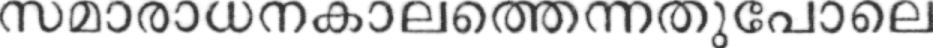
സമാരാധനകാലത്തെന്നതുപോലെ
